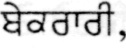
ਬੇਕਰਾਰੀ,
